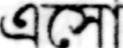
এসো
